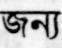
জন্য
